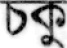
চকু
